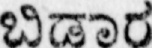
ಬಿಡಾರ
